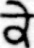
ਕੇ
